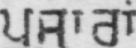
ਪਸਾਰਾਂ
